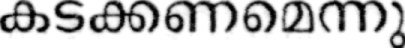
കടക്കണമെന്നു
